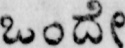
ಒಂದೇ
